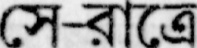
সে-রাত্রে
